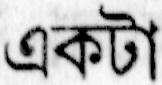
একটা
